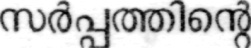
സര്‍പ്പത്തിന്റെ
